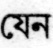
যেন
